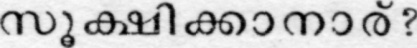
സൂക്ഷിക്കാനാര്?
